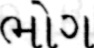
ભોગ
